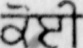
ਕੋਈ
